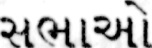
સભાઓ
